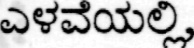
ಎಳವೆಯಲ್ಲಿ,
